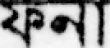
ফনা
